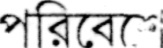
পরিবেশে
